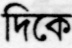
দিকে
